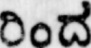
ರಿಂದ
